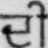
ਦੀ
